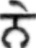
ਨੇ
